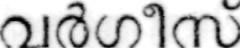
വര്‍ഗീസ്
